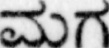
ಮಗ
